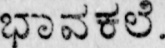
ಭಾವಕಲೆ.
